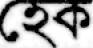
হেক
